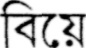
বিয়ে
